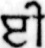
ਈ
